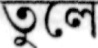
তুলে
